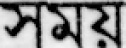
সময়
